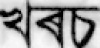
খৰচ
